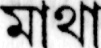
মাথা
